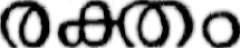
രക്തം
